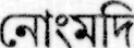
নোংমদি
